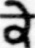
ਕੇ
